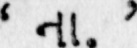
'ના.'
